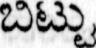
ಬಿಟ್ಟು
